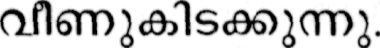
വീണുകിടക്കുന്നു.
